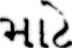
માટે
